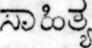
ಸಾಹಿತ್ಯ
